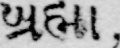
બ્રહ્મા,
